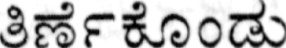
ತಿರ್ಣೆಕೊಂಡು
